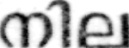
നില
